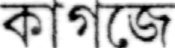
কাগজে
